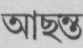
আছন্ত
